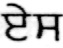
ਏਸ
